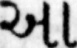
આ
